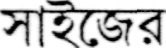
সাইজের
